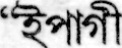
“ইপাগী
